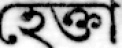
হেক্তা
